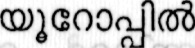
യൂറോപ്പില്‍
